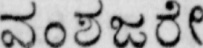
ವಂಶಜರೇ
